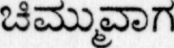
ಚಿಮ್ಮುವಾಗ
